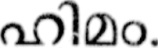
ഹിമം.
